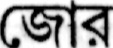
জোর
